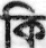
কি
